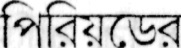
পিরিয়ডের
